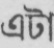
এটা
